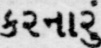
કરનારું
